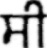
ਸੀ
